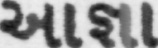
આજ્ઞા
